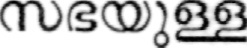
സഭയുള്ള
